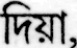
দিয়া,
